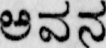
ಅವನ
